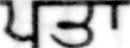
ਪਤਾ
